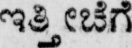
ಇತ್ತೀಚೆಗೆ
